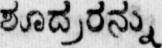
ಶೂದ್ರರನ್ನು
